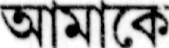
আমাকে
